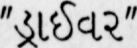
"ડ્રાઈવર"
